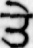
ਤੇ
